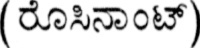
(ರೊಸಿನಾಂಟ್)
